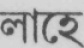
লাহে
